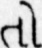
તો
